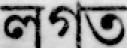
লগত
